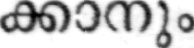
ക്കാനും
